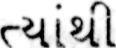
ત્યાંથી
